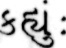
કહ્યું:
